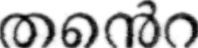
തന്റെ
